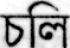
চলি
